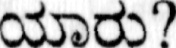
ಯಾರು?
